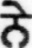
ਨੇ
